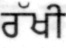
ਰੱਖੀ
